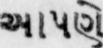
આપણે
